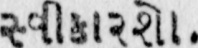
સ્વીકારશો.
